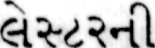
લેસ્ટરની
